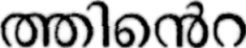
ത്തിന്റെ
